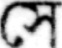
সে
